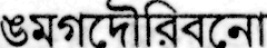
ঙমগদৌরিবনো
